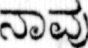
ನಾವು
